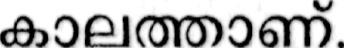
കാലത്താണ്.
